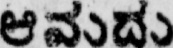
ಆಮದು
